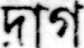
দাগ
